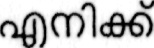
എനിക്ക്
